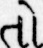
તો
